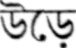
উড়ে
